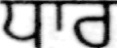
ਧਾਰ
